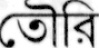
তৌরি
